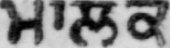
ਮਾਲਕ
